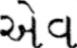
એવ
